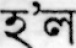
হ'ল
